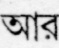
আর
